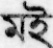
মই
